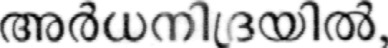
അര്‍ധനിദ്രയില്‍,
